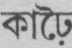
কাঢ়ৈ
